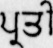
ਪ੍ਰਤੀ
